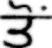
ਤੋਂ
